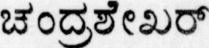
ಚಂದ್ರಶೇಖರ್
